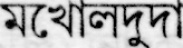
মখোলদুদা
